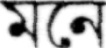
মনে
